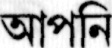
আপনি
